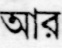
আর
